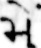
મેં
